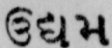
ઉદ્યમ
